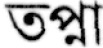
তপ্না
